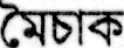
মৈচাক
